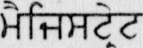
ਮੈਜਿਸਟ੍ਰੇਟ
